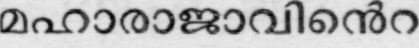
മഹാരാജാവിന്റെ
